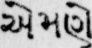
એમણે
